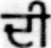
ਦੀ
